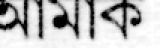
আমাক
